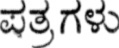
ಪತ್ರಗಳು
